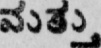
ಮತ್ತು
